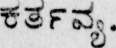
ಕರ್ತವ್ಯ.
